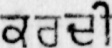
ਕਰਦੀ
